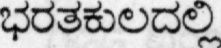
ಭರತಕುಲದಲ್ಲಿ
